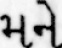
મને
